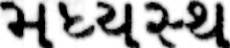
મધ્યસ્થ
